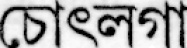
চোৎলগা
